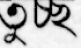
তুচ্ছ
